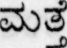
ಮತ್ತೆ
